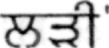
ਲੜੀ'
